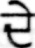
ਦੇ
